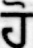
ਹੋ
